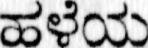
ಹಳೆಯ
